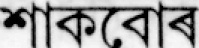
শাকবোৰ
